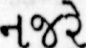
નજરે
